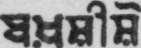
ਬਖ਼ਸ਼ੀਸ਼ੋ
